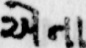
એના
